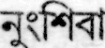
নুংশিবা
